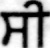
ਸੀ
